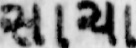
સાચા
